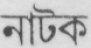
নাটক
